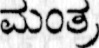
ಮಂತ್ರ
